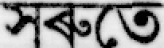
সৰুতে
